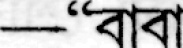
-“বাবা
